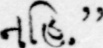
નહિ."
